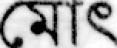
মোৎ
